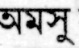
অমসু
